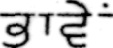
ਭਾਵੇਂ
